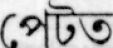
পেটত
